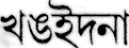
খঙইদনা
